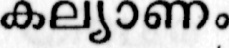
കല്യാണം
